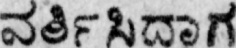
ವರ್ತಿಸಿದಾಗ
